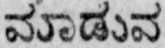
ಮಾಡುವ
